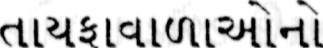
તાયફાવાળાઓનો
